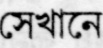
সেখানে
